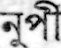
নুপী
